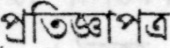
প্রতিজ্ঞাপত্র
